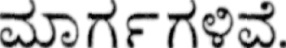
ಮಾರ್ಗಗಳಿವೆ.
